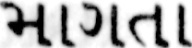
માગતા
